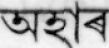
অহাৰ
